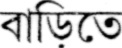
বাড়িতে
